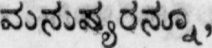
ಮನುಷ್ಯರನ್ನೂ,
